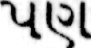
પણ
